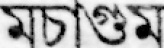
মচাগুম
